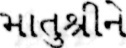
માતુશ્રીને
